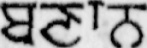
ਬਣਾਨ
